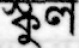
স্কুল
